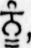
ਨੂੰ,
